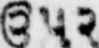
ઉપર
